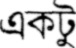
একটু
